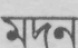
মদন
